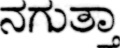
ನಗುತ್ತಾ
